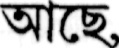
আছে,
